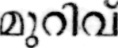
മുറിവ്
